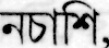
নচাশি,
